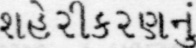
શહેરીકરણનું
